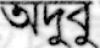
অদুবু
